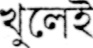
খুলেই
